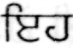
ਇਹ
